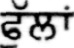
ਫੁੱਲਾਂ
